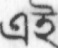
এই
